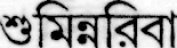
শুমিন্নরিবা
